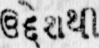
ઉદ્દેશથી
